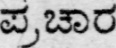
ಪ್ರಚಾರ
